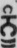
ਨੂੰ
